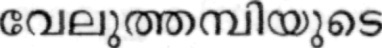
വേലുത്തമ്പിയുടെ
